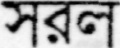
সরল
